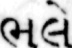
ભલે
